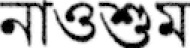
নাওশুম
